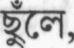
ছুঁলে,
